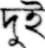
দুই
